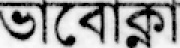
ভাবোক্না
